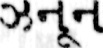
ઝનૂન
